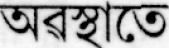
অৱস্হাতে
